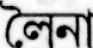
লৈনা
